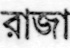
রাজা
